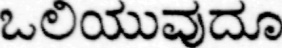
ಒಲಿಯುವುದೂ
